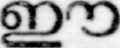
ഈ
